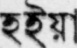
হইয়া
